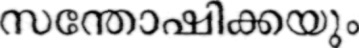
സന്തോഷിക്കയും
